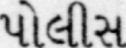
પોલીસ
